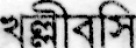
খল্লীবসি
